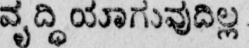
ವೃದ್ಧಿಯಾಗುವುದಿಲ್ಲ.
